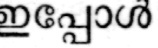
ഇപ്പോള്‍
